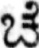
ಚೆ
